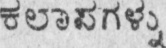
ಕಲಾಪಗಳ್ನು
